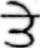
ਤੇ
